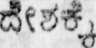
ದೇಶಕ್ಕೆ
